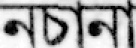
নচানা
